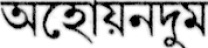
অহোয়নদুম
